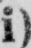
i)
